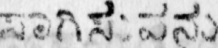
ಸಾಗಿಸುವನು
